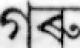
গৰু
